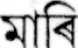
মাৰি
